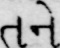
તને
